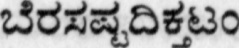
ಬೆರಸಷ್ಟದಿಕ್ತಟಂ
